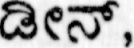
ಡೀನ್,
